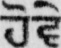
ਹੋਵੇ
